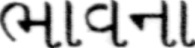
ભાવના
